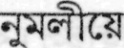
নুমলীয়ে
